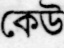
কেউ
